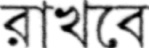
রাখবে
